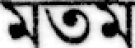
মতম
